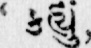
'કહ્યું,
